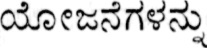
ಯೋಜನೆಗಳನ್ನು
